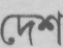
দেশ
